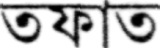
তফাত
